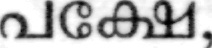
പക്ഷേ,
